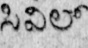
ಸಿವಿಲ್
